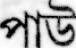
পাউ
